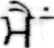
ਮੈਂ
